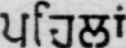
ਪਹਿਲਾਂ
